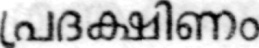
പ്രദക്ഷിണം
